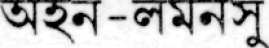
অহন-লমনসু
